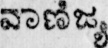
ವಾಣಿಜ್ಯ
